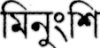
মিনুংশি
